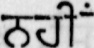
ਨਹੀਂ
